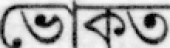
ভোকত
